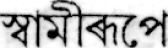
স্বামীৰূপে
